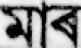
মাৰ
